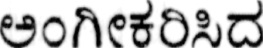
ಅಂಗೀಕರಿಸಿದ
